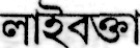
লাইবক্তা
